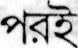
পরই
